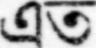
এত
